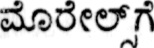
ಮೊರೇಲ್ಸ್ಗೆ
